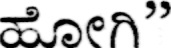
ಹೋಗಿ"
